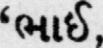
'ભાઈ,
